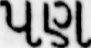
પણ
